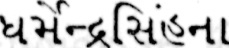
ધર્મેન્દ્રસિંહના
